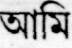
আমি
